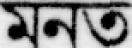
মনত
